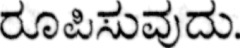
ರೂಪಿಸುವುದು.
